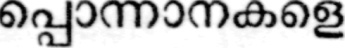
പ്പൊന്നാനകളെ
